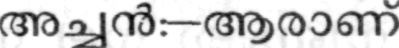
അച്ചന്‍:-ആരാണ്
